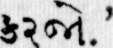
કરજો.'
